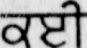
ਕਈ
